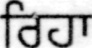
ਰਿਹਾ
